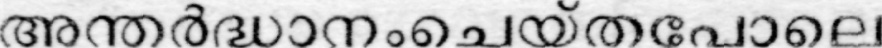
അന്തര്‍ദ്ധാനംചെയ്തപോലെ
